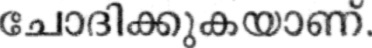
ചോദിക്കുകയാണ്.
